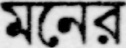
মনের
